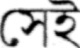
সেই
